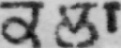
ਕਲਾ
